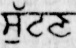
ਸੁੱਟਣ
